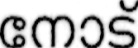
നോട്
